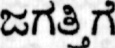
ಜಗತ್ತಿಗೆ
